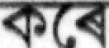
কৰে
